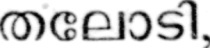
തലോടി,
